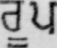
ਰੂਪ
